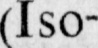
(Iso-
